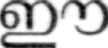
ഈ
